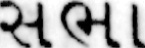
સભા
